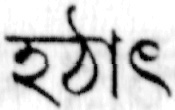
হঠাৎ
